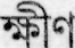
ক্ষীণ
